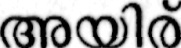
അയിര്
